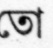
তো
